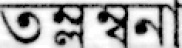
তম্লম্বনা
